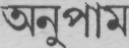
অনুপাম
